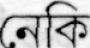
নেকি
